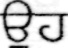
ਉਹ
